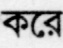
করে
